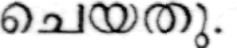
ചെയതു.
